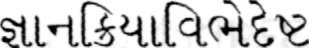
જ્ઞાનક્રિયાવિભેદેષ્ટ
